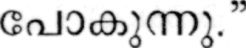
പോകുന്നു."
